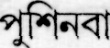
পুশিনবা
